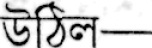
উঠিল-
